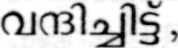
വന്ദിച്ചിട്ട്,
